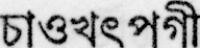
চাওখৎপগী
